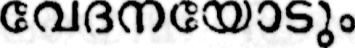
വേദനയോടും
